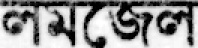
লমজেল
